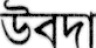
উবদা
